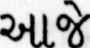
આજે
